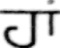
ਹਾਂ
